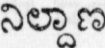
ನಿಲ್ದಾಣ
